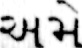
અમે
